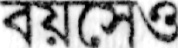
বয়সেও
